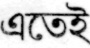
এতেই
